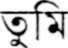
তুমি
